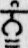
ਨੂੰ
